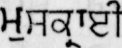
ਮੁਸਕ੍ਰਾਈ
